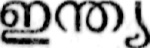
ഇന്ത്യ
